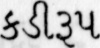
કડીરૂપ
